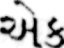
એક
